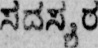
ಸದಸ್ಯರ
